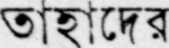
তাহাদের
